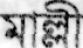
মাল্লী
